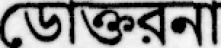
ডোক্তরনা
